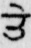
ਤੇ
